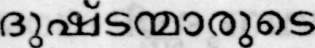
ദുഷ്ടന്മാരുടെ
